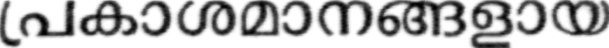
പ്രകാശമാനങ്ങളായ
